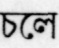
চলে
